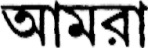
আমরা
